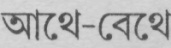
আথে-বেথে
